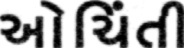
ઓચિંતી
